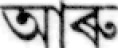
আৰু
